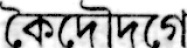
কৈদৌদগে
